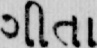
ગીતા
